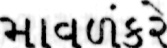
માવળંકરે
